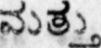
ಮತ್ತು
